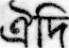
ঐদি
